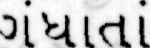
ગંધાતાં
